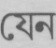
যেন
